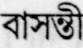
বাসন্তী
